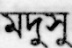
মদুসু
